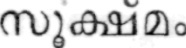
സൂക്ഷ്മം
